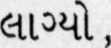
લાગ્યો,
